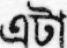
এটা
